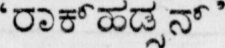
‘ರಾಕ್‌ಹಡ್ಸನ್’
